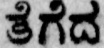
ತೆಗೆದ
